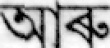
আৰু
